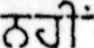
ਨਹੀਂ
